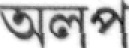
অলপ
